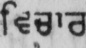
ਵਿਚਾਰ
